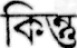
কিন্তু
